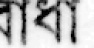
বাধা
